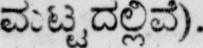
ಮಟ್ಟದಲ್ಲಿವೆ).
